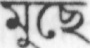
মুছে
